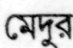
মেদুর
